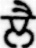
ਲੈ
